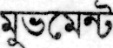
মুভমেন্ট
